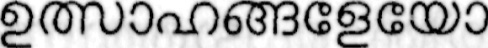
ഉത്സാഹങ്ങളേയോ
